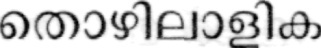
തൊഴിലാളിക
